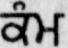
ਕੰਮ
